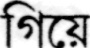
গিয়ে
